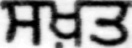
ਸਖ਼ਤ
